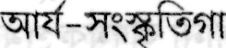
আর্য-সংস্কৃতিগা
